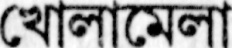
খোলামেলা
